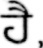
ਹੈ,
